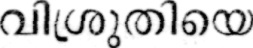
വിശ്രുതിയെ
